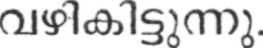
വഴികിട്ടുന്നു.
